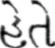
હેતે
